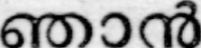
ഞാന്‍
